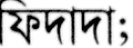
ফিদাদা;
